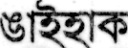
ঙাইহাক
